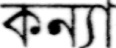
কন্যা
